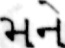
મને
